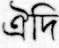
ঐদি
